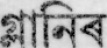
গ্লানিৰ
